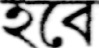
হবে
